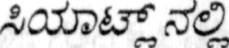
ಸಿಯಾಟ್ಲ್‌ನಲ್ಲಿ
